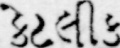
કેટલીક
